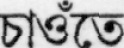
চাওঁতে
